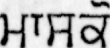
ਮਾਸਕੋ
